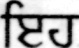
ਇਹ
